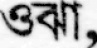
ওঝা,
